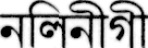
নলিনীগী
